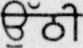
ਉੱਠੀ
